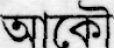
আকৌ
